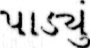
પાડ્યું
